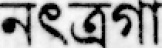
নৎত্রগা
